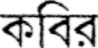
কবির
